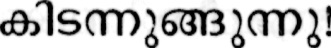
കിടന്നുങ്ങുന്നു!
